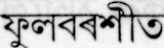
ফুলবৰশীত
